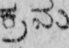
ಕ್ರಮ
